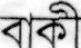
বাকী
